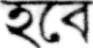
হবে
